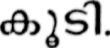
കൂടി.
